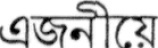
এজনীয়ে
